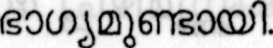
ഭാഗ്യമുണ്ടായി.
